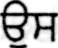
ਉਸ
